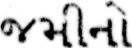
જમીનો
